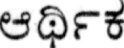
ಆರ್ಥಿಕ
